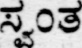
ಸ್ವಂತ
